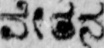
ವೇತನ
